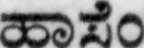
ಹಾಸೆಂ
